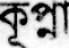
কূপ্না
